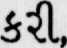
કરી,
